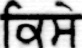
ਕਿਸੇ
